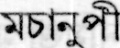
মচানুপী
